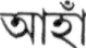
আহাঁ
